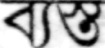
ব্যস্ত
